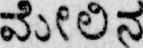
ಮೇಲಿನ
